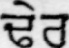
ਢੇਰ
